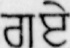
ਗਏ
